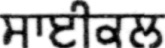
ਸਾਈਕਲ
